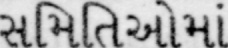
સમિતિઓમાં
